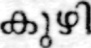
കുഴി
